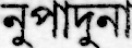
নুপাদুনা
